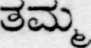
ತಮ್ಮ
